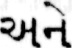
અને
